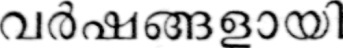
വര്‍ഷങ്ങളായി
